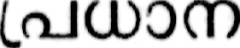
പ്രധാന
